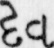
દેવ
